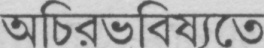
অচিরভবিষ্যতে
